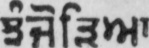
ਝੰਜੋੜਿਆ
